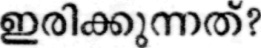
ഇരിക്കുന്നത്?
